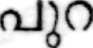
പുറ
